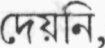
দেয়নি,
